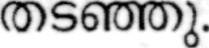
തടഞ്ഞു.
